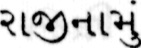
રાજીનામું
